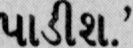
પાડીશ.'
